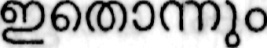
ഇതൊന്നും
